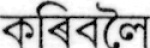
কৰিবলৈ
